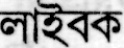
লাইবক
